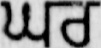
ਘਰ
